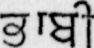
ਭਾਬੀ
